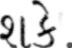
શકે.
